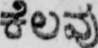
ಕೆಲವು
